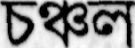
চঞ্চল
